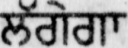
ਲੱਗੇਗਾ
